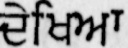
ਦੇਖਿਆ
